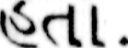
હતા.
